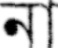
না
